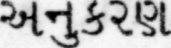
અનુકરણ
